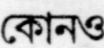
কোনও
